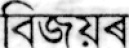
বিজয়ৰ
